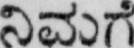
ನಿಮಗೆ
